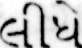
લીધે
